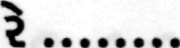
રે..........
